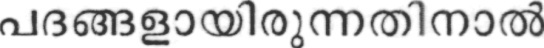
പദങ്ങളായിരുന്നതിനാല്‍
